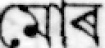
মোৰ
